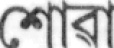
শোৱা
